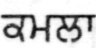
ਕਮਲਾ
